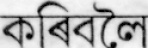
কৰিবলৈ
